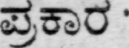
ಪ್ರಕಾರ
